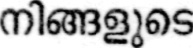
നിങ്ങളുടെ
